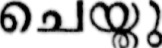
ചെയ്തു
